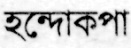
হন্দোকপা
